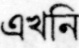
এখনি
